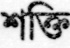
শক্তি
